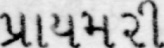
પ્રાયમરી
